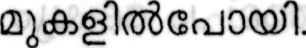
മുകളില്‍പോയി.
